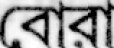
বোরা
